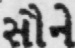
સૌને
